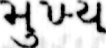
મુખ્ય
